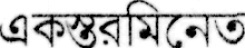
একস্তরমিনেত
